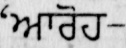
'ਆਰੋਹ-
